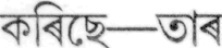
কৰিছে-তাৰ
